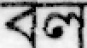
বল
